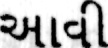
આવી
